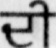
ਦੀ
